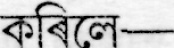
কৰিলে-
